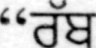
''ਰੱਬ
